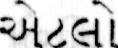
એટલો
